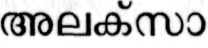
അലക്സാ
